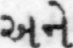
અને
